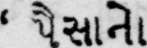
'પૈસાનો
